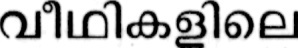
വീഥികളിലെ
